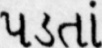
પડતાં
